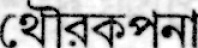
থৌরকপনা
